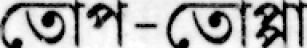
তোপ-তোপ্পা
